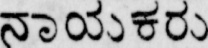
ನಾಯಕರು
